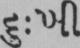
દુઃખી
